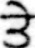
ਤੇ
